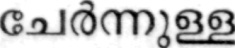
ചേര്‍ന്നുള്ള
